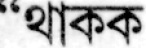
"থাকক
